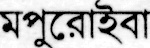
মপুরোইবা
